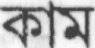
কাম
